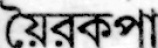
য়ৈরকপা
